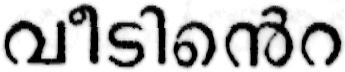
വീടിന്റെ
